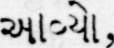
આવ્યો,
